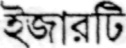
ইজারটি
